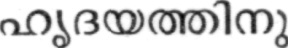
ഹൃദയത്തിനു
